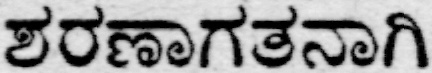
ಶರಣಾಗತನಾಗಿ
